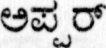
ಅಪ್ಪರ್
